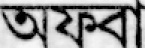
অফবা
